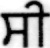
ਸੀ
